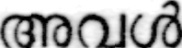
അവള്‍
